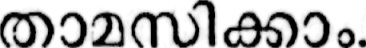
താമസിക്കാം.
